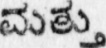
ಮತ್ತು
